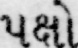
પક્ષો
